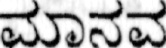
ಮಾನವ
